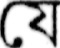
যে
